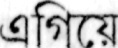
এগিয়ে
